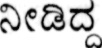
ನೀಡಿದ್ದ
